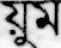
য়ুম
